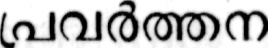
പ്രവര്‍ത്തന
